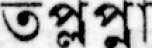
তপ্লপ্না
